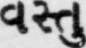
વસ્તુ
